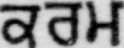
ਕਰਮ
